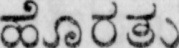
ಹೊರತು
